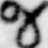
જ
